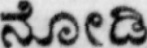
ನೋಡಿ
